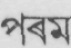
পৰম
